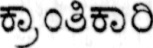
ಕ್ರಾಂತಿಕಾರಿ
